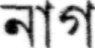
নাগ
